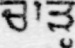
ਚਾੜ੍ਹ
